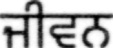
ਜੀਵਨ
